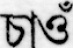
চাওঁ
